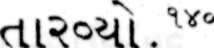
તારવ્યો.૧૪૦
